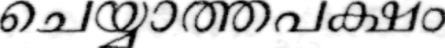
ചെയ്യാത്തപക്ഷം
